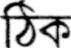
ঠিক
